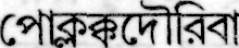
পোক্লক্কদৌরিবা
